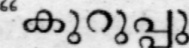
"കുറുപ്പു
